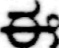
ಈ
